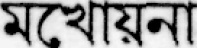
মখোয়না
